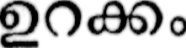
ഉറക്കം
